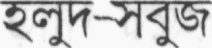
হলুদ-সবুজ
